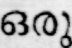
ഒരു
